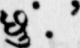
છું.
